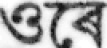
ওৰে
